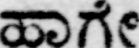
ಹಾಗೇ
